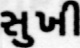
સુખી
